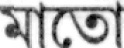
মাতো
